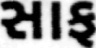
સાફ
